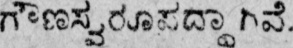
ಗೌಣಸ್ವರೂಪದ್ದಾಗಿವೆ.
